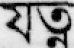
যত্ন
